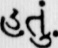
હતું.
